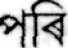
পৰি
